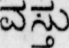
ವಸ್ತು
